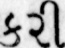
કરી
